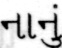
નાનું
